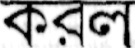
করল
